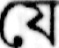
যে
